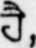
ਹੈ,
